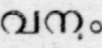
വനം
